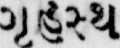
ગૃહસ્થ
